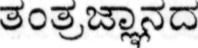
ತಂತ್ರಜ್ಞಾನದ
